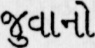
જુવાનો
